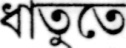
ধাতুতে
